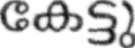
കേട്ടു
